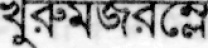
খুরুমজরম্লে
